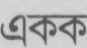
একক
